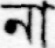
না
